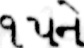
૧૫ને
